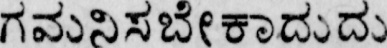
ಗಮನಿಸಬೇಕಾದುದು
